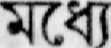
মধ্যে
